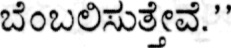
ಬೆಂಬಲಿಸುತ್ತೇವೆ."
